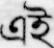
এই
